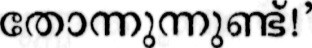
തോന്നുന്നുണ്ട്!’
